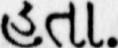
હતા.
